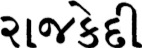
રાજકેદી
